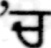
'ਚ
